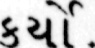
કર્યો.
